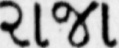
રાજા
